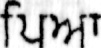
ਪਿਆ
